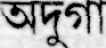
অদুগা
